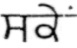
ਸਕੇਂ
